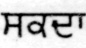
ਸਕਦਾ
